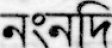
নংনদি
